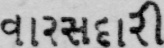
વારસદારી
